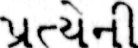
પ્રત્યે
